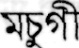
মচুগী
